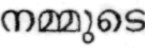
നമ്മുടെ
